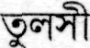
তুলসী
